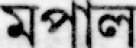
মপাল
